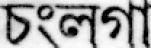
চংলগা
